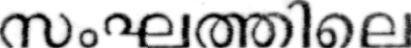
സംഘത്തിലെ
